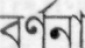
বৰ্ণনা
